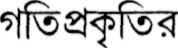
গতিপ্রকৃতির
